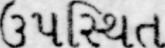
ઉપસ્થિત
